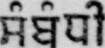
ਸੰਬੰਧੀ
